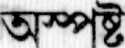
অস্পষ্ট
